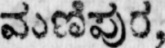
ಮಣಿಪುರ,
